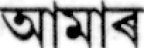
আমাৰ
